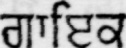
ਗਾਇਕ
